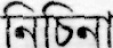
নিচিনা
